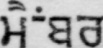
ਮੈਂਬਰ
